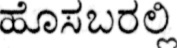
ಹೊಸಬರಲ್ಲಿ
